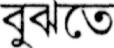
বুঝতে
